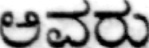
ಅವರು
